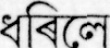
ধৰিলে
